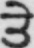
ਤੇ
